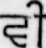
ਵੀ
